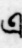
এ
